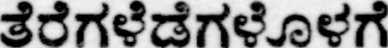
ತೆರೆಗಳೆಡೆಗಳೊಳಗೆ
